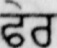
ਫੇਰ
